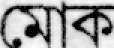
মোক
